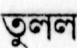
তুলল
